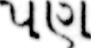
પણ
